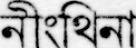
নীংথিনা
